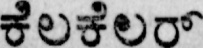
ಕೆಲಕೆಲರ್
